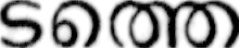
ടത്തെ
